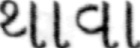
થાવા
